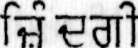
ਜ਼ਿੰਦਗੀ
